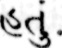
હતું.
